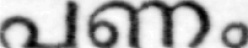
പണം
